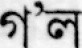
গ'ল
